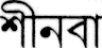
শীনবা
